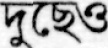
দুছেও
